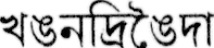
খঙনদ্রিঙৈদা
